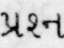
પ્રશ્ન
